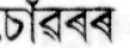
চোঁৱৰৰ
